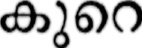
കുറെ
